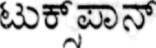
ಟುಕ್ಸ್ಪಾನ್
